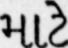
માટે
